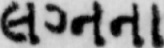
લગ્નના
